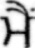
ਮੈਂ
